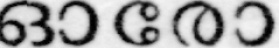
ഓരോ
